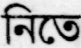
নিতে
